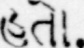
હતો.
